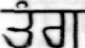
ਤੰਗ
